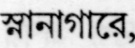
স্নানাগারে,
